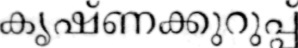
കൃഷ്ണക്കുറുപ്പ്
